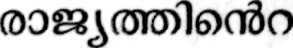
രാജ്യത്തിന്റെ
